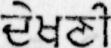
ਦੇਖਣੀ
